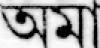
অমা
